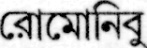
রোমোনিবু
